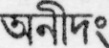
অনীদং
